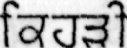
ਕਿਹੜੀ
